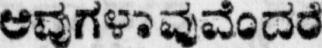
ಅವುಗಳಾವುವೆಂದರೆ
